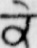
ਕੇ
